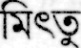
মিৎতু
